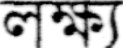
লক্ষ্য
